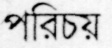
পরিচয়
